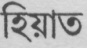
হিয়াত
